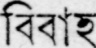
বিবাহ
